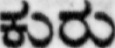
ಕುರು
